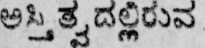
ಅಸ್ತಿತ್ವದಲ್ಲಿರುವ
